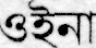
ওইনা
